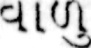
વાળુ
